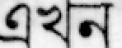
এখন
